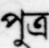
পুত্র
